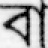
বা
